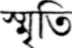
স্মৃতি
